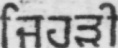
ਜਿਹੜੀ
